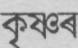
কৃষ্ণৰ
